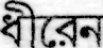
ধীরেন
